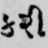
કરી
